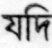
যদি
